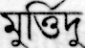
মুর্ত্তিদু
